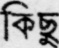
কিছু
